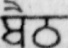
ਬੈਠ
